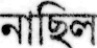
নাছিল
